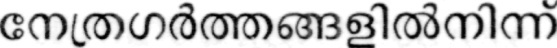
നേത്രഗര്‍ത്തങ്ങളില്‍നിന്ന്
